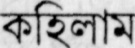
কহিলাম
